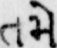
તમે
